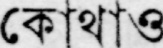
কোথাও
